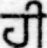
ਹੀ
